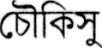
চৌকিসু
